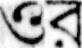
ওর
